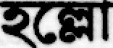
হল্লো
